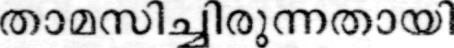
താമസിച്ചിരുന്നതായി
